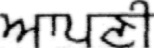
ਆਪਣੀ
